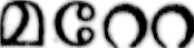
മറേറ
